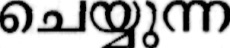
ചെയ്യുന്ന
